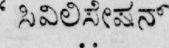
‘ಸಿವಿಲಿಸೇಷನ್
